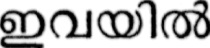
ഇവയില്‍
